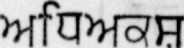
ਅਧਿਅਕਸ਼
